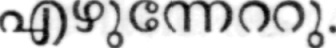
എഴുന്നേററു.
